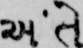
અંતે
